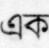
এক
